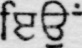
ਇਉਂ
